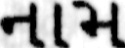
નામ
